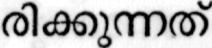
രിക്കുന്നത്
